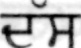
ਦੱਸ
